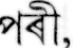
পৰী,
